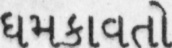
ધમકાવતો
